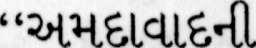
"અમદાવાદની
